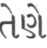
તેણે
